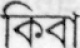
কিবা
